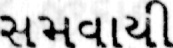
સમવાયી
